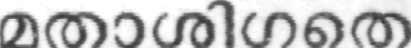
മതാശിഗതെ
